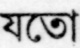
যতো
